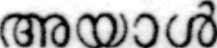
അയാള്‍
